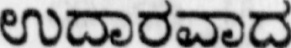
ಉದಾರವಾದ
